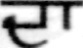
ਦਾ
